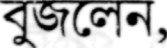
বুজলেন,
